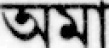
অমা
